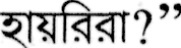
হায়রিবা?”
